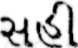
સહી
